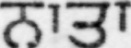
ਨਾਤਾ
